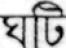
ঘটি
